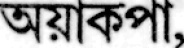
অয়াকপা,
